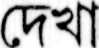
দেখা
